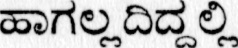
ಹಾಗಲ್ಲದಿದ್ದಲ್ಲಿ
